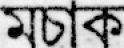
মচাক
